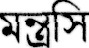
মন্ত্রসি
